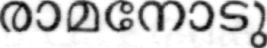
രാമനോടു
